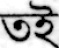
তই
